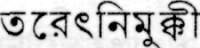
তরেৎনিমুক্কী
